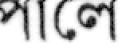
পালে
